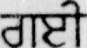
ਗਈ
